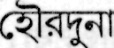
হৌরদুনা
